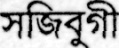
সজিবুগী
